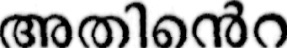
അതിന്റെ
